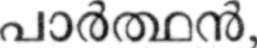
പാര്‍ത്ഥന്‍,
